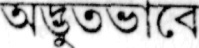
অদ্ভুতভাবে
